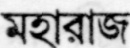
মহারাজ
